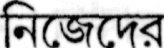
নিজেদের
